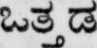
ಒತ್ತಡ
